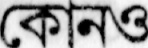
কোনও
